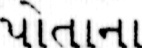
પોતાના
